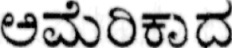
ಅಮೆರಿಕಾದ
